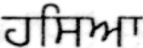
ਹਸਿਆ
